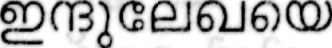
ഇന്ദുലേഖയെ
